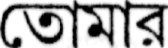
তোমার
